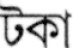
টকা
